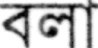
বলা
